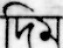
দিম
